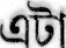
এটা
